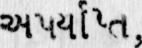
અપર્યાપ્ત,
